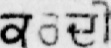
ਕਰਦੀ
